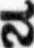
ನ
